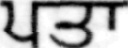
ਪਤਾ
